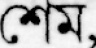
শেম,
